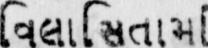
વિલાસિતામાં
